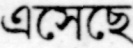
এসেছে
